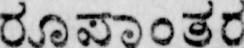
ರೂಪಾಂತರ
